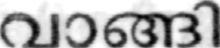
വാങ്ങി
